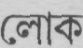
লোক
